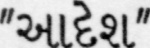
"આદેશ"
